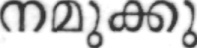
നമുക്കു
